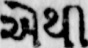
એથી
